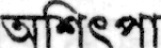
অশিৎপা
